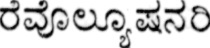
ರೆವೊಲ್ಯೂಷನರಿ
